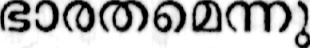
ഭാരതമെന്നു
